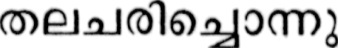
തലചരിച്ചൊന്നു
